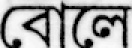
বোলে
